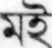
মই
